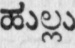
ಹುಲ್ಲು
